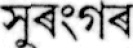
সুৰংগৰ
